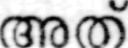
അത്
